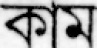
কাম
